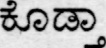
ಕೊಡ್ತಾ
